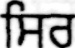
ਸਿਰ
